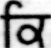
ਕਿ
